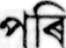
পৰি
